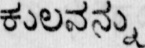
ಕುಲವನ್ನು
